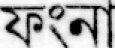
ফংনা
